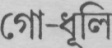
গো-ধূলি
